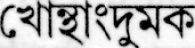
খোন্থাংদুমক
